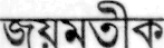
জয়মতীক
